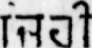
ਜਿਹੀ
